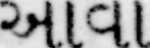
આવા
